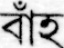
বাঁহ
